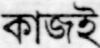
কাজই
